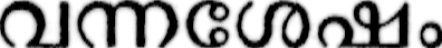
വന്നശേഷം
